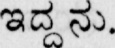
ಇದ್ದನು.
